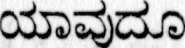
ಯಾವುದೂ
